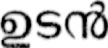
ഉടന്‍
